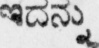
ಇದನ್ನು
